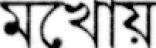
মখোয়
